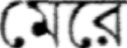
মেরে
